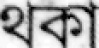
থকা
